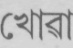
খোৱা
